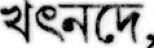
খৎনদে,
